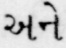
અને
